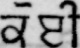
ਕੋਈ
